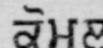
ਕੋਮਲ
